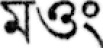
মওং
